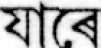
যাৰে
